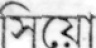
সিয়ো
